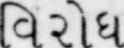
વિરોધ
